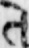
તે
